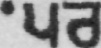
'ਪਰ
